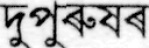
দুপুৰুষৰ
